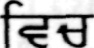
ਵਿਚ
